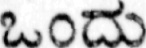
ಒಂದು
